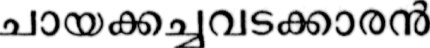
ചായക്കച്ചവടക്കാരന്‍
